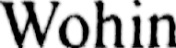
Wohin
